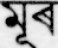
মূৰ
